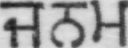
ਜਨਮ
